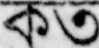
কত
